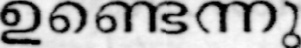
ഉണ്ടെന്നു
